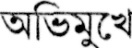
অভিমুখে
